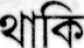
থাকি
